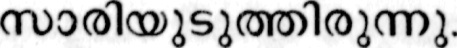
സാരിയുടുത്തിരുന്നു.
